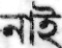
নাই
